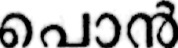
പൊന്‍
